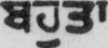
ਬਹੁਤਾ
